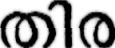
തിര
